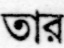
তার
